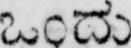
ಒಂದು
